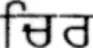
ਚਿਰ
